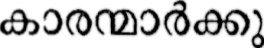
കാരന്മാര്‍ക്കു
